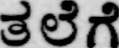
ತಲೆಗೆ
